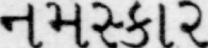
નમસ્કાર
